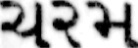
ચરમ
